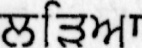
ਲੜਿਆ
